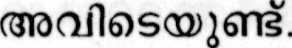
അവിടെയുണ്ട്.
